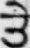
ਤੇ
